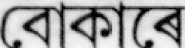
বোকাৰে
